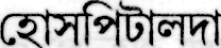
হোসপিটালদা
